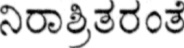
ನಿರಾಶ್ರಿತರಂತೆ
